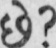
છે?
